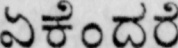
ಏಕೆಂದರೆ
